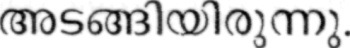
അടങ്ങിയിരുന്നു.
